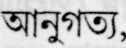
আনুগত্য,
